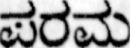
ಪರಮ
